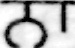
ਨਾ
